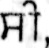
ਸੀ,
